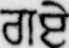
ਗਏ
